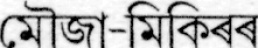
মৌজা-মিকিৰৰ
